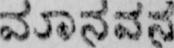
ಮಾನವನ
